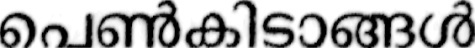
പെണ്‍കിടാങ്ങള്‍
